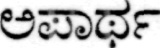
ಅಪಾರ್ಥ
